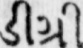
ડીગ્રી
